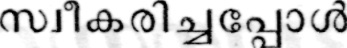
സ്വീകരിച്ചപ്പോള്‍
